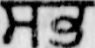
ਸਭ
